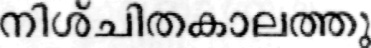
നിശ്ചിതകാലത്തു
